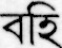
বহি
